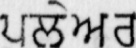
ਪਲੇਅਰ
